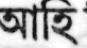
আহি
